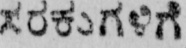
ಸರಕುಗಳಿಗೆ
